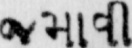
જમાવી
